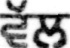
ਵੱਲ
